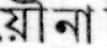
য়ৌনা
